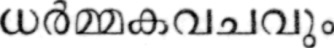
ധര്‍മ്മകവചവും
